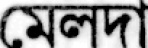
মেলদা
